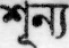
শূন্য
